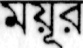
ময়ূর
